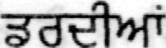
ਡਰਦੀਆਂ
